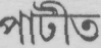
পাটীত
